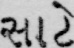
સાટે
